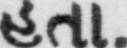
હતા.
